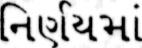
નિર્ણયમાં
